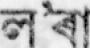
ল'ৰা
